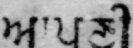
ਆਪਣੀ
